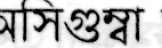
অসিগুম্বা
